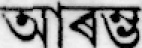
আৰম্ভ
